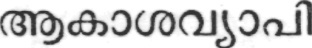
ആകാശവ്യാപി
